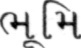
ભૂમિ
